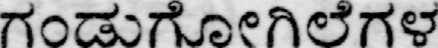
ಗಂಡುಗೋಗಿಲೆಗಳ
